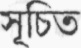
সূচিত
